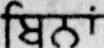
ਬਿਨਾਂ
